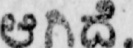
ಆಗಿದೆ.
